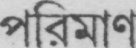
পরিমাণ
